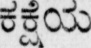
ಕಕ್ಷೆಯ
